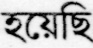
হয়েছি
